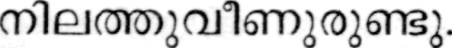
നിലത്തുവീണുരുണ്ടു.
